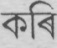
কৰি
